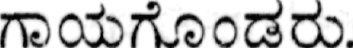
ಗಾಯಗೊಂಡರು.
